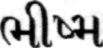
ભીષ્મ
